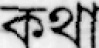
কথা
